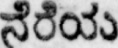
ನೆರೆಯ
